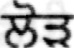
ਲੋੜ
